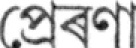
প্রেৰণা
